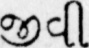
જીવી
